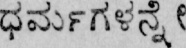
ಧರ್ಮಗಳನ್ನೇ
